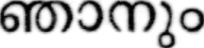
ഞാനും
